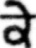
ਕੇ
